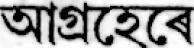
আগ্রহেৰে
